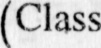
(Class
